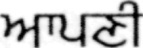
ਆਪਣੀ
